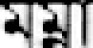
মম্না
